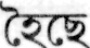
হৈছে
